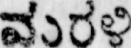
ಮರಳಿ
